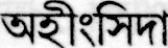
অহীংসিদা
